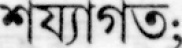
শয্যাগত;
